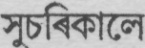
সুচৰিকালে
